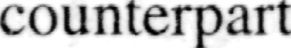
counterpart
